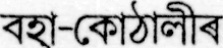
বহা-কোঠালীৰ
